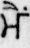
ਮੈਂ
